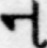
ન
